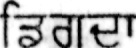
ਡਿਗਦਾ
